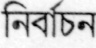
নির্বাচন
